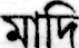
মাদি
